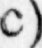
c)
